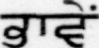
ਭਾਵੇਂ
